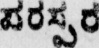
ಪರಸ್ಪರ
